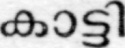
കാട്ടി
